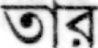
তার
